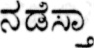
ನಡೆಸ್ತಾ
